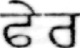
ਫੇਰ
